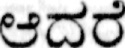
ಆದರೆ
